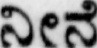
ನೀನೆ
